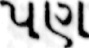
પણ
